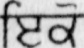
ਇਕੋ
